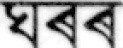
ঘৰৰ
